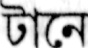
টানে
